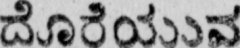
ದೊರೆಯುವ
